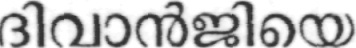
ദിവാന്‍ജിയെ
